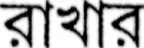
রাখার
